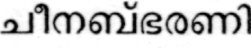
ചീനബ്ഭരണി
